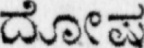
ದೋಷ
